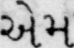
એમ
